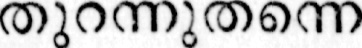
തുറന്നുതന്നെ
